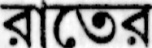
রাতের
